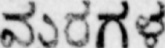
ಮರಗಳ
